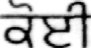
ਕੋਈ
